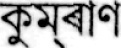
কুম্‌ৰাণ
